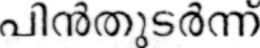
പിന്‍തുടര്‍ന്ന്
